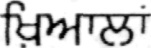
ਖ਼ਿਆਲਾਂ
